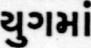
યુગમાં
